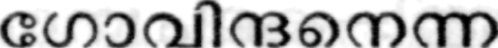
ഗോവിന്ദനെന്ന
